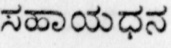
ಸಹಾಯಧನ
